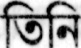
তিনি
